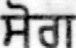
ਸੋਗ
